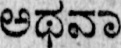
ಅಥವಾ
